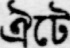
ঐটে
